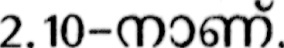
2.10-നാണ്.
